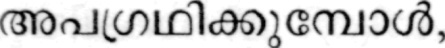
അപഗ്രഥിക്കുമ്പോള്‍,
